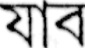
যাব
